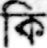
কি
